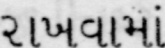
રાખવામાં
